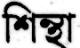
শিন্থা
